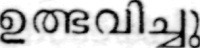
ഉത്ഭവിച്ചു
